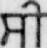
ਸੀ
